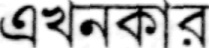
এখনকার
